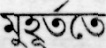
মুহূর্ততে
